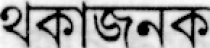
থকাজনক
